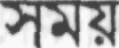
সময়
